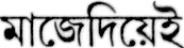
মাজেদিয়েই
